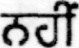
ਨਹੀਂ
